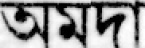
অমদা
